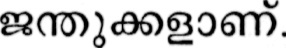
ജന്തുക്കളാണ്.
